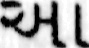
આ
